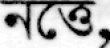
নত্তে,
